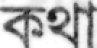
কথা
